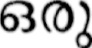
ഒരു
